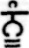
ਨੂੰ
